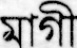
মাগী
